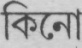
কিনো
